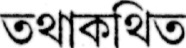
তথাকথিত
